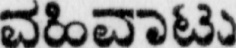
ವಹಿವಾಟು
